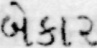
બેકાર
